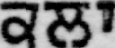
ਕਲਾ
